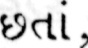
છતાં,
